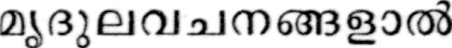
മൃദുലവചനങ്ങളാല്‍
